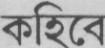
কহিবে
